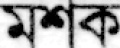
মশক
